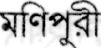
মণিপুরী
